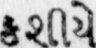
કશીયે
